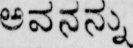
ಅವನನ್ನು
